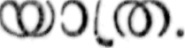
യാത്ര.
